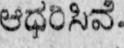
ಆಧರಿಸಿವೆ.
